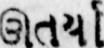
ઊતર્યા
